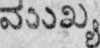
ಮುಖ್ಯ
